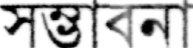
সম্ভাবনা
